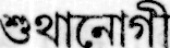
শুথানোগী
